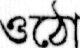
ওঠো
